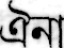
ঐনা
